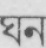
ঘন
